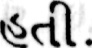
હતી.
